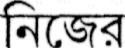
নিজের
